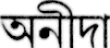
অনীদা
